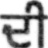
ਦੀ
